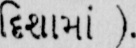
દિશામાં).
